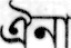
ঐনা
